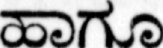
ಹಾಗೂ
